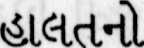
હાલતનો
